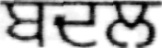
ਬਦਲ
